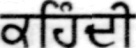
ਕਹਿੰਦੀ
